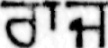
ਰਾਜ
